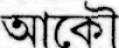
আকৌ
